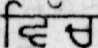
ਵਿੱਚ
